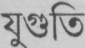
যুগুতি
